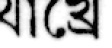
থাখ্রে
